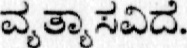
ವ್ಯತ್ಯಾಸವಿದೆ.
